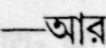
–আর
